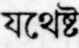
যথেষ্ট
